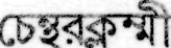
চেন্থরক্লম্মী
